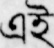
এই
